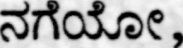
ನಗೆಯೋ,
